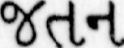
જતન
